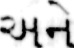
અને
